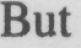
But
